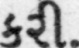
કરી.
